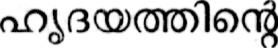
ഹൃദയത്തിന്റെ
